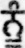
ਨੂੰ
